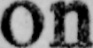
on
